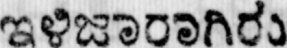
ಇಳಿಜಾರಾಗಿರು
